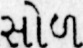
સોળ
